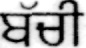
ਬੱਚੀ
